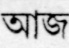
আজ
